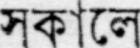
সকালে
